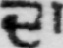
ਦਾ
